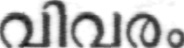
വിവരം
